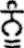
ਨੂੰ
